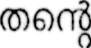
തന്റെ
